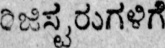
ರಿಜಿಸ್ಟರುಗಳಿಗೆ
